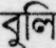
বুলি
